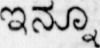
ಇನ್ನೂ
